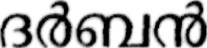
ദര്‍ബന്‍
